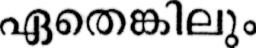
ഏതെങ്കിലും
